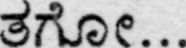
ತಗೋ...
